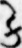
કે
